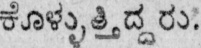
ಕೊಳ್ಳುತ್ತಿದ್ದರು.
